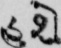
હશે
